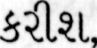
કરીશ,
